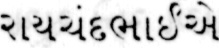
રાયચંદભાઈએ
